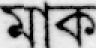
মাক
